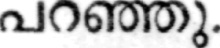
പറഞ്ഞു.
